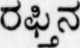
ರಫ್ತಿನ
